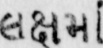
લક્ષમાં
